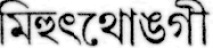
মিহুৎথোঙগী
